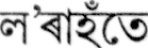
ল'ৰাহঁতে
